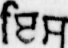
ਇਸ
